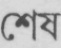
শেষ
